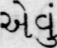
એવું
